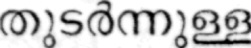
തുടര്‍ന്നുള്ള
